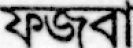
ফজবা
